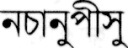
নচানুপীসু
